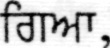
ਗਿਆ,
